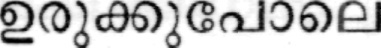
ഉരുക്കുപോലെ
